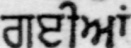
ਗਈਆਂ
